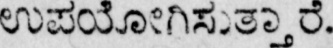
ಉಪಯೋಗಿಸುತ್ತಾರೆ.
